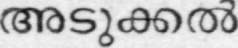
അടുക്കല്‍
